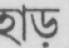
হাড়
